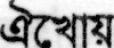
ঐখোয়
